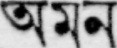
অমন
